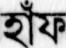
হাঁফ
